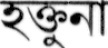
হক্তুনা
